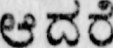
ಆದರೆ
